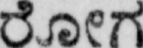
ರೋಗ
